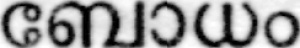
ബോധം
